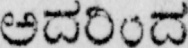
ಅದರಿಂದ
